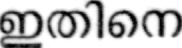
ഇതിനെ
